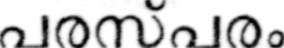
പരസ്പരം
